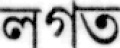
লগত
